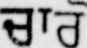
ਚਾਰੋ
